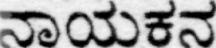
ನಾಯಕನ
